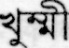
খুম্মী
